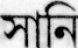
সানি
